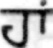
ਹਾਂ
